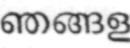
ഞങ്ങള
